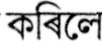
কৰিলে
